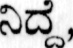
ನಿದ್ದೆ,
